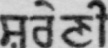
ਸ਼ਰੇਣੀ
